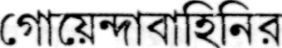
গোয়েন্দাবাহিনির
